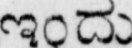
ಇಂದು
